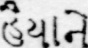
હૈયાને
